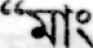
“মাং
